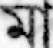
মা
